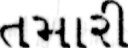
તમારી
